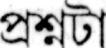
প্রশ্নটা
